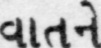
વાતને
